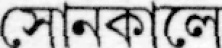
সোনকালে
